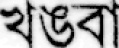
খঙবা
